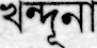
খন্দূনা
